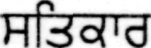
ਸਤਿਕਾਰ
